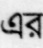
এর
